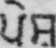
ਪੇਸ਼
